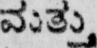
ಮತ್ತು
